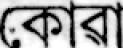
কোৱা
